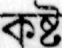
কষ্ট
